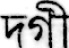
দগী
